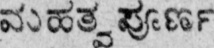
ಮಹತ್ವಪೂರ್ಣ
